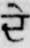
ਦੇ
